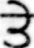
ਤੇ
